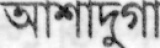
আশাদুগা
